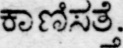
ಕಾಣಿಸತ್ತೆ.
